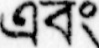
এবং
